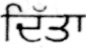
ਦਿੱਤਾ
